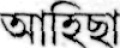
আহিছা
